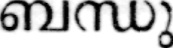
ബന്ധു
